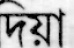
দিয়া
